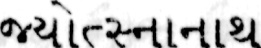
જ્યોત્સ્નાનાથ
